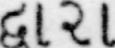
દ્વારા
